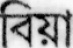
বিয়া
